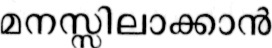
മനസ്സിലാക്കാന്‍
